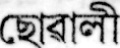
ছোৱালী
